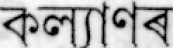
কল্যাণৰ
